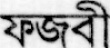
ফজবী
